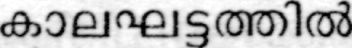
കാലഘട്ടത്തില്‍
